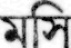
মসি
